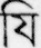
যি
